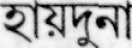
হায়দুনা
